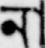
না
